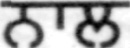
ਨਾਲ
